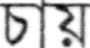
চায়
